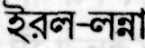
ইরল-লন্না
